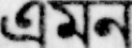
এমন
